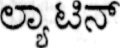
ಲ್ಯಾಟಿನ್
